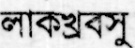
লাকখ্রবসু
